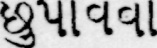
છુપાવવા
